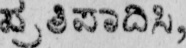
ಪ್ರತಿಪಾದಿಸಿ,
